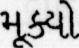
મૂક્યો
